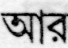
আর
